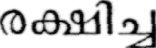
രക്ഷിച്ച
